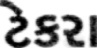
ટેકરા
